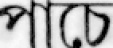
পাচে
